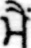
ਮੈਂ
